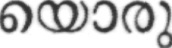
യൊരു
